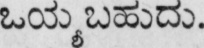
ಒಯ್ಯಬಹುದು.
